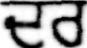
ਦਰ
